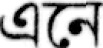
এনে
